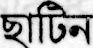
ছাটিন
